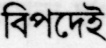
বিপদেই
